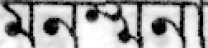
মনম্মনা
